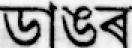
ডাঙৰ
